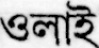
ওলাই
